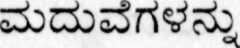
ಮದುವೆಗಳನ್ನು
